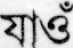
যাওঁ
